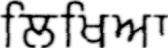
ਲਿਖਿਆ
